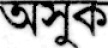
অসুক
